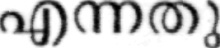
എന്നതു
